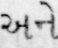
અને
